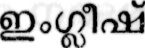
ഇംഗ്ലീഷ്
